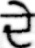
ਦੇ
